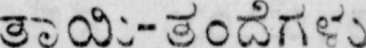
ತಾಯಿ-ತಂದೆಗಳು
